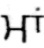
ਮਾਂ
